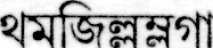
থমজিল্লম্লগা
